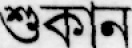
শুকান
